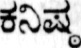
ಕನಿಷ್ಠ
